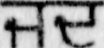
ਜਦ
